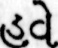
હવે
